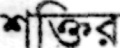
শক্তির
